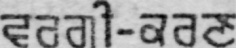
ਵਰਗੀ-ਕਰਣ
